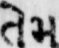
તેમ
